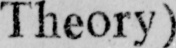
Theory)
